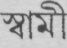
স্বামী
